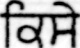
ਕਿਸੇ
